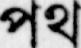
পথ
